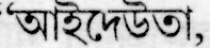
"আইদেউতা,
